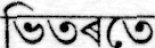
ভিতৰতে
